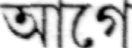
আগে
